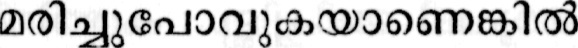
മരിച്ചുപോവുകയാണെങ്കില്‍
